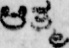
ಆತ್ಮ
